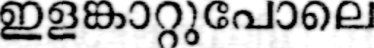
ഇളങ്കാറ്റുപോലെ
